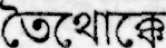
তৈথোক্কে
